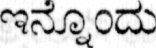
ಇನ್ನೊಂದು
